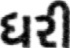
ધરી
